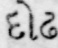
દોઢ
